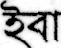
ইবা
